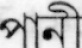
পানী
